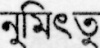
নুমিৎতু
